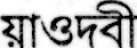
য়াওদবী
